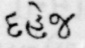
દહેજ
